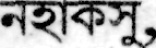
নহাকসু,
